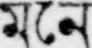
মনে
